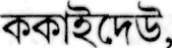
ককাইদেউ,
